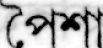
পৈশা
